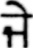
ਜੇ
